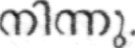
നിന്നു.
